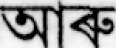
আৰু
